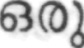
ഒരു
